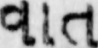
વાત
